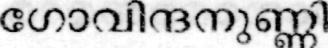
ഗോവിന്ദനുണ്ണി
